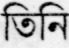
তিনি
